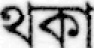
থকা
